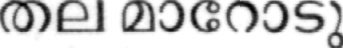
തലമാറോടു
